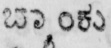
ಬ್ಯಾಂಕು
